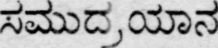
ಸಮುದ್ರಯಾನ
